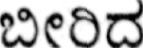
ಬೀರಿದ
